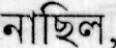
নাছিল,
